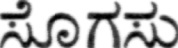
ಸೊಗಸು
